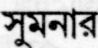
সুমনার
